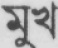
মুখ
